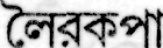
লৈরকপা
